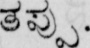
ತಪ್ಪು.
